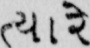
ત્યારે
